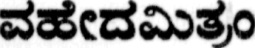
ವಹೇದಮಿತ್ರಂ
